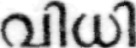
വിധി
